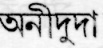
অনীদুদা
